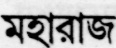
মহারাজ
